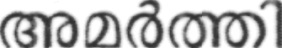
അമര്‍ത്തി
